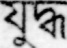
যুদ্ধ
